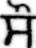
ਸੌ
